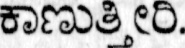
ಕಾಣುತ್ತೀರಿ.
